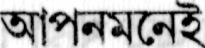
আপনমনেই
